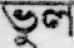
ভুল
